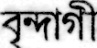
বৃন্দাগী
